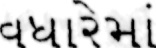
વઘારેમાં
